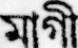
মাগী
